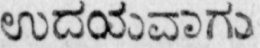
ಉದಯವಾಗು
